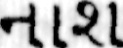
નાશ
